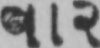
વાર
